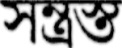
সন্ত্রস্ত
